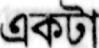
একটা
